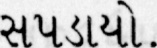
સપડાયો.
